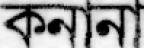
কনানা
